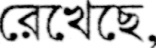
রেখেছে,
